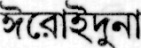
ঈরোইদুনা
